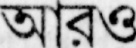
আরও
